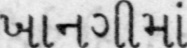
ખાનગીમાં
